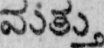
ಮತ್ತು
